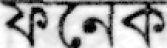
ফনেক
